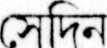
সেদিন
